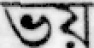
ভয়
